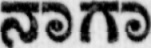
ನಾಗಾ
